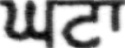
ਘਟਾ
